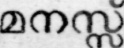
മനസ്സ്
